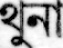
থুনা
